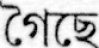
গৈছে
